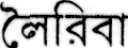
লৈরিবা
